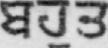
ਬਹੁਤ
